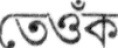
তেওঁক
